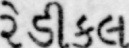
રેડીકલ
